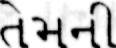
તેમની
